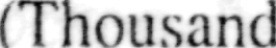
(Thousand
